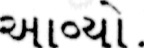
આવ્યો.
